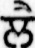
ਲੈ
